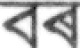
বৰ
